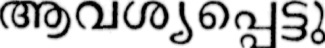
ആവശ്യപ്പെട്ടു
